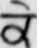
ਕੇ
